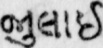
જુલાઈ
